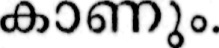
കാണും.
